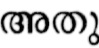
അതു
